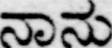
ನಾನು
